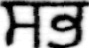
ਸਭ
